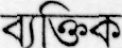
ব্যক্তিক
